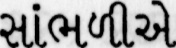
સાંભળીએ
